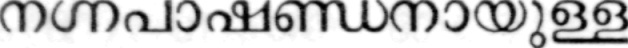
നഗ്നപാഷണ്ഡനായുള്ള
